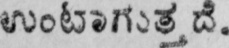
ಉಂಟಾಗುತ್ತದೆ.
